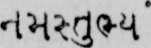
નમસ્તુભ્યં
